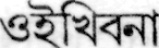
ওইখিবনা
